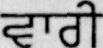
ਵਾਰੀ
